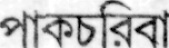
পাকচরিবা
